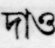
দাও
